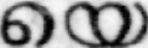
യെ
